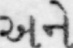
અને
